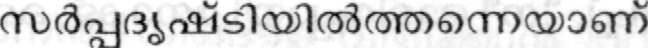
സര്‍പ്പദൃഷ്ടിയില്‍ത്തന്നെയാണ്
